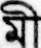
মী
